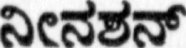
ನೀನಶನ್
